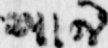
આજે
